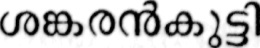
ശങ്കരന്‍കുട്ടി
